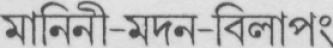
মানিনী-মদন-বিলাপং
